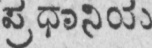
ಪ್ರಧಾನಿಯ
